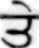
ਤੇ
